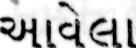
આવેલા
